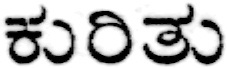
ಕುರಿತು
